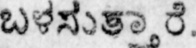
ಬಳಸುತ್ತಾರೆ.
